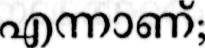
എന്നാണ്;
